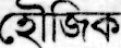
হৌজিক
